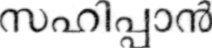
സഹിപ്പാന്‍
